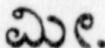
ಮೀ.
